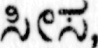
ಸೀಸ,
